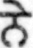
ਨੇ
